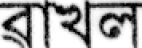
ৱাখল
